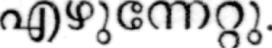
എഴുന്നേറ്റു.
